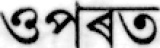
ওপৰত
